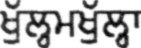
ਖੁੱਲ੍ਹਮਖੁੱਲ੍ਹਾ
